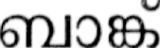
ബാങ്ക്
